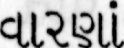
વારણાં
